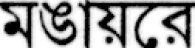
মঙায়রে
